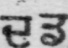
ਦਡ
